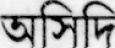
অসিদি
